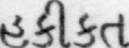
હકીકત
